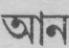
আন
